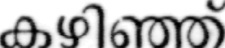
കഴിഞ്ഞ്
